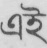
এই
